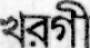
খরগী
